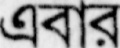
এবার
